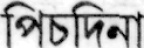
পিচদিনা
